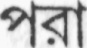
পরা
